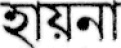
হায়না
